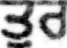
ਤੁਰ
